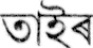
তাইৰ
